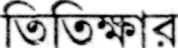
তিতিক্ষার
